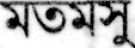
মতমসু
